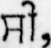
ਸੀ,
